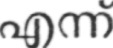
എന്ന്
